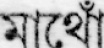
মাথোঁ
